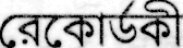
রেকোর্ডকী
